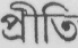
প্রীতি
